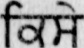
ਕਿਸੇ
